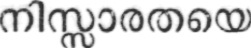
നിസ്സാരതയെ
